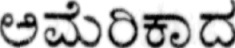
ಅಮೆರಿಕಾದ
